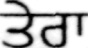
ਤੇਰਾ
